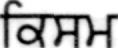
ਕਿਸਮ
